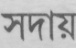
সদায়
